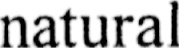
natural
